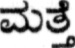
ಮತ್ತೆ
